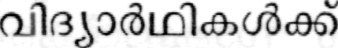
വിദ്യാര്‍ഥികള്‍ക്ക്
